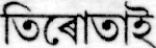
তিৰোতাই
